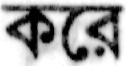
করে
